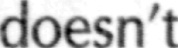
doesn't
